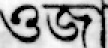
ওজা
